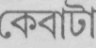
কেবাটা
